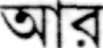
আর
